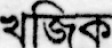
খজিক
